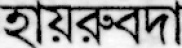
হায়রুবদা
